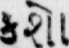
કશો
